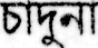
চাদুনা
